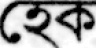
হেক
